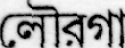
লৌরগা
